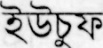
ইউচুফ
